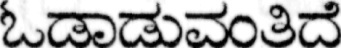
ಓಡಾಡುವಂತಿದೆ
